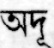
অদূ
